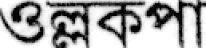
ওল্লকপা
